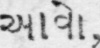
આવો,
